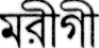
মরীগী
